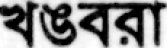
খঙবরা
